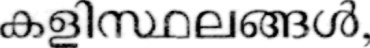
കളിസ്ഥലങ്ങള്‍,
